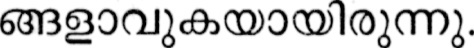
ങ്ങളാവുകയായിരുന്നു.
